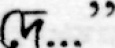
দে..."
